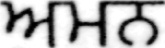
ਅਮਨ
